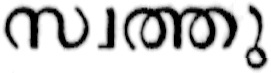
സ്വത്തു
